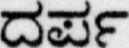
ದರ್ಪ
